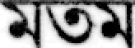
মতম
